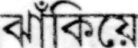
ঝাঁকিয়ে
